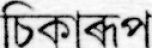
চিকাৰূপ
